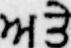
ਅਤੇ
